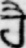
ਹੈ
